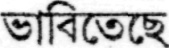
ভাবিতেছে
